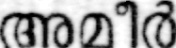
അമീര്‍
